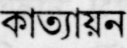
কাত্যায়ন
